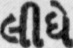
લીધે
